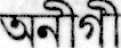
অনীগী
